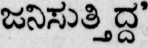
ಜನಿಸುತ್ತಿದ್ದ’
